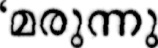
‘മരുന്നു
